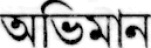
অভিমান
